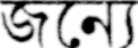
জন্যে
